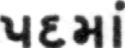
પદમાં
